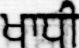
ਖਾਧੀ
